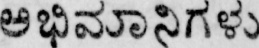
ಅಭಿಮಾನಿಗಳು
